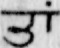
ਤਾਂ
